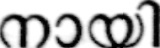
നായി
